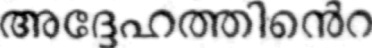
അദ്ദേഹത്തിന്റെ
